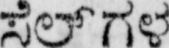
ಸೆಲ್ಗಳ
